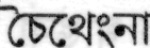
চৈথেংনা
